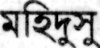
মহিদুসু
